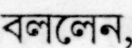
বললেন,
